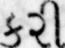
કરી
